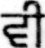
ਵੀ
